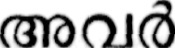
അവര്‍
